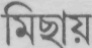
মিছায়
